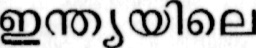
ഇന്ത്യയിലെ
